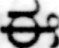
ಈ
